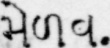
મેળવ.
